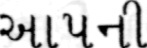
આપની
